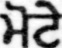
ਮੋਟੇ
